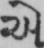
એ
